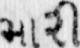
મારી
